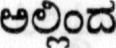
ಅಲ್ಲಿಂದ
